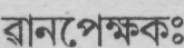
ৱানপেক্ষকঃ
